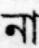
না
